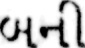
બની
